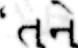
'તને
